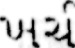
ખર્ચ
